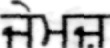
ਜੇਮਜ਼
